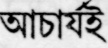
আচার্যই
